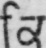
ਕਿ
